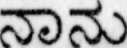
ನಾನು
